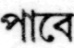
পাবে
